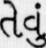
તેવું
